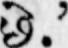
છે.'
